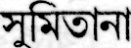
সুমিতানা
